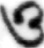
ও
